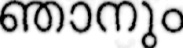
ഞാനും
